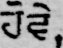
ਹੋਵੇ,
